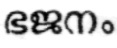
ഭജനം
